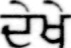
ਦੇਖੇ
